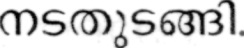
നടതുടങ്ങി.
